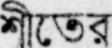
শীতের
